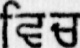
ਵਿਚ
